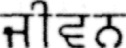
ਜੀਵਨ
